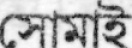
সোমাই
